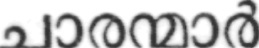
ചാരന്മാര്‍
